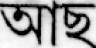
আছ
